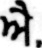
ਐ,
